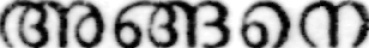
അങ്ങനെ
